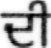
ਦੀ
